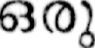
ഒരു
